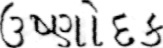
ઉષ્ણોદક
